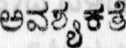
ಅವಶ್ಯಕತೆ
